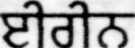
ਈਰੀਨ
